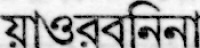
য়াওরবনিনা
